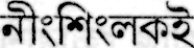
নীংশিংলকই
